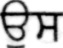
ਉਸ
